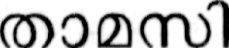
താമസി
